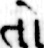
તો
